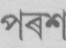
পৰশ
